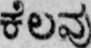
ಕೆಲವು
